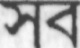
সব
